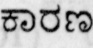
ಕಾರಣ
